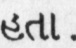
હતા.
